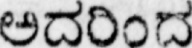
ಅದರಿಂದ
